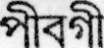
পীবগী
